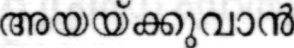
അയയ്ക്കുവാന്‍
